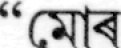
"মোৰ
